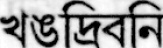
খঙদ্রিবনি
